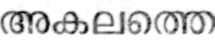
അകലത്തെ
